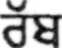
ਰੱਬ
